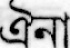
ঐনা
